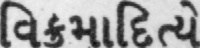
વિક્રમાદિત્યે
